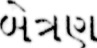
બેત્રણ
